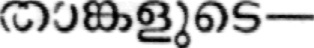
താങ്കളുടെ-
